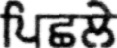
ਪਿਛਲੇ
